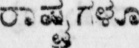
ರಾಷ್ಟ್ರಗಳೂ
